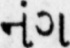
નંગ
